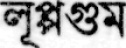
লূপ্পগুম
